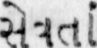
સેવતાં
